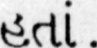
હતાં.
